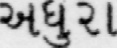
અધૂરા
